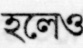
হলেও
